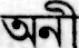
অনী
